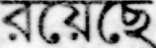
রয়েছে
